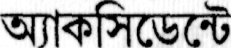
অ্যাকসিডেন্টে
